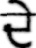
ਦੇ
